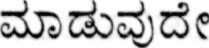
ಮಾಡುವುದೇ
